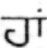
ਹਾਂ
